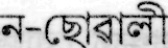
ন-ছোৱালী
